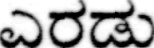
ಎರಡು
